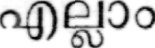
എല്ലാം
